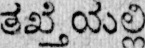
ತಖ್ತೆಯಲ್ಲಿ
